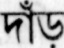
দাঁড়
